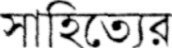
সাহিত্যের
